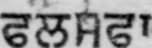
ਫਲਸਫਾ
